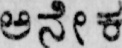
ಅನೇಕ
